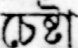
চেষ্টা
